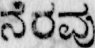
ನೆರವು
